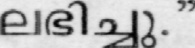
ലഭിച്ചു."
